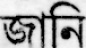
জানি
